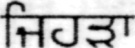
ਜਿਹੜਾ
